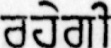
ਰਹੇਗੀ
